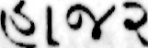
હાજર
